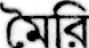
মৈরি
